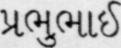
પ્રભુભાઈ
